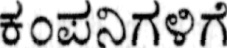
ಕಂಪನಿಗಳಿಗೆ
